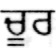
ਚੂਰ
